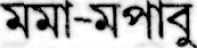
মমা-মপাবু
